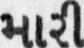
મારી
